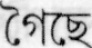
গৈছে
